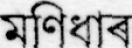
মণিধাৰ
